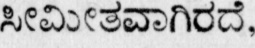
ಸೀಮೀತವಾಗಿರದೆ,
